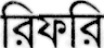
রিফরি
